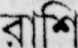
রাশি
